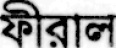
ফীরাল
